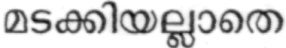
മടക്കിയതല്ലാതെ
